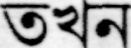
তখন
